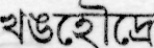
খঙহৌদ্রে
